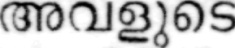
അവളുടെ
